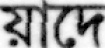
য়াদে
